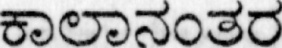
ಕಾಲಾನಂತರ
